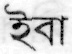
ইবা
